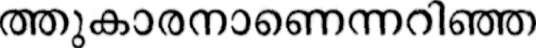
ത്തുകാരനാണെന്നറിഞ്ഞ
